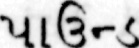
પાઉન્ડ
